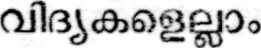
വിദ്യകളെല്ലാം
